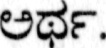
ಅರ್ಥ.
